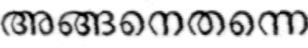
അങ്ങനെതന്നെ
